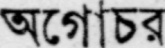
অগোচর
